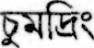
চুমদ্রিং
